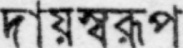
দায়স্বরূপ
